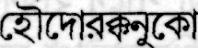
হৌদোরক্কনুকো
